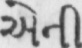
એની
